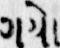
ગયો
